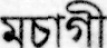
মচাগী
